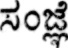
ಸಂಜ್ಞೆ
